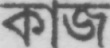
কাজ
